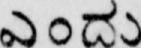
ಎಂದು
